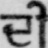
ਦੀ
